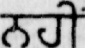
ਨਹੀਂ
